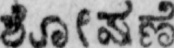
ಶೋಷಣೆ
